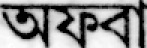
অফবা
